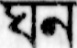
ঘন
